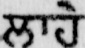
ਲਾਹੇ
